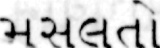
મસલતો
